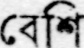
বেশি
